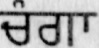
ਚੰਗਾ
